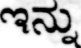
ಇನ್ನು
